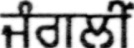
ਜੰਗਲੀਂ
